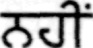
ਨਹੀਂ
